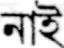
নাই
